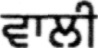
ਵਾਲੀ
